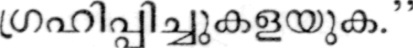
ഗ്രഹിപ്പിച്ചുകളയുക."
